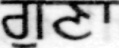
ਗੁਣਾ
